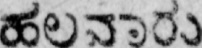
ಹಲವಾರು
